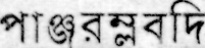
পাঞ্জরম্লবদি
